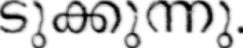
ടുക്കുന്നു.
